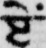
ਏਂ
